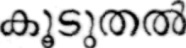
കൂടുതല്‍
